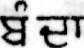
ਬੰਦਾ
